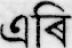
এৰি
